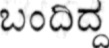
ಬಂದಿದ್ದ
